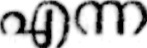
എന്ന
